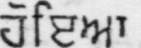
ਹੋਇਆ
